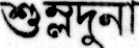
শুম্লদুনা
